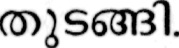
തുടങ്ങി.
